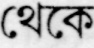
থেকে
